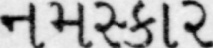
નમસ્કાર
